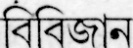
বিবিজান
